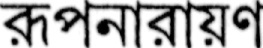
রূপনারায়ণ
